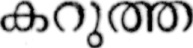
കറുത്ത
